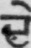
ਦੇ
